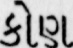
કોણ
